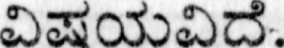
ವಿಷಯವಿದೆ.
